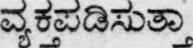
ವ್ಯಕ್ತಪಡಿಸುತ್ತಾ
